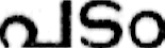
പടം
